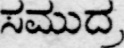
ಸಮುದ್ರ
